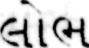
લોભ
